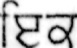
ਇਕ
